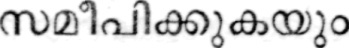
സമീപിക്കുകയും
